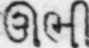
ઊભી
